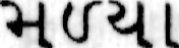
મળ્યા
